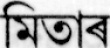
মিতাৰ
